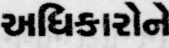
અધિકારોને
